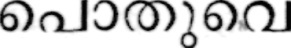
പൊതുവെ
